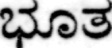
ಭೂತ
